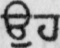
ਉਹ
